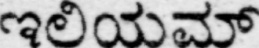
ಇಲಿಯಮ್
